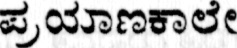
ಪ್ರಯಾಣಕಾಲೇ
